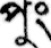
পুং
